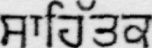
ਸਾਹਿੱਤਕ
